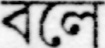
বলে
